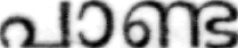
പാണ്ട
